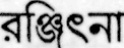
রঞ্জিৎনা
